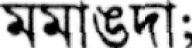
মমাঙদা;
